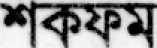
শকফম
